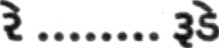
રે.......રૂડે
